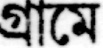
গ্রামে
